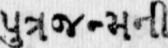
પુત્રજન્મની
